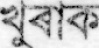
খুৰাক
